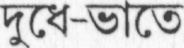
দুধে-ভাতে
